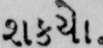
શક્યો.
